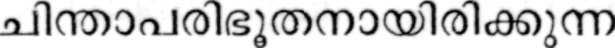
ചിന്താപരിഭൂതനായിരിക്കുന്ന
